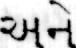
અને
